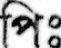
পিঃ
